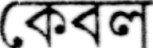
কেবল
